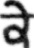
ਕੇ
